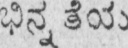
ಭಿನ್ನತೆಯ
